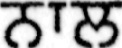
ਨਾਲ
